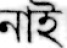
নাই
